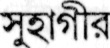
সুহাগীর
